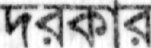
দরকার
